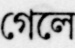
গেলে
